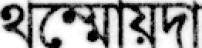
থম্মোয়দা
